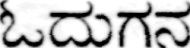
ಓದುಗನ
